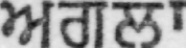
ਅਗਲਾ
